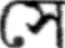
সে
